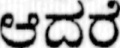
ಆದರೆ
